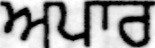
ਅਪਾਰ
